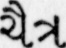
ચૈત્ર
